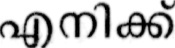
എനിക്ക്
